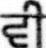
ਵੀ
